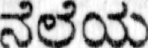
ನೆಲೆಯ
